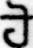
ਹੋ
